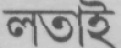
লতাই
